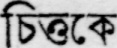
চিত্তকে
